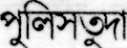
পুলিসতুদা
